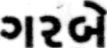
ગરબે
